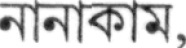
নানাকাম,
